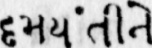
દમયંતીને
